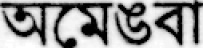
অমেঙবা
